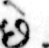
છે.
